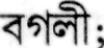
বগলী;
